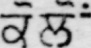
ਕੋਲੋਂ
